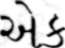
એક
